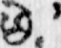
છે.
